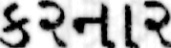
કરનાર
